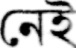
নেই
